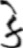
કે
